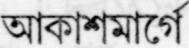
আকাশমার্গে
